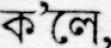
ক'লে,
